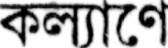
কল্যাণে
